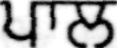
ਪਾਲ
